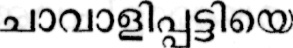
ചാവാളിപ്പട്ടിയെ
